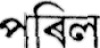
পৰিল
